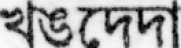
খঙদেদা
